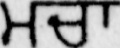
ਮਚਾ
